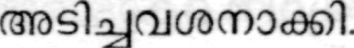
അടിച്ചവശനാക്കി.
